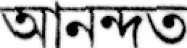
আনন্দত
